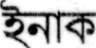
ইনাক
